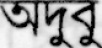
অদুবু
